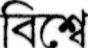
বিশ্বে
